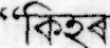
"কিহৰ
